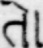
તો
